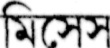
মিসেস
